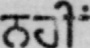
ਨਹੀਂ
